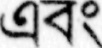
এবং
